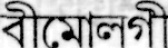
বীমোলগী
